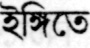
ইঙ্গিতে
